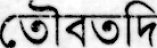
তৌবতদি
